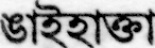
ঙাইহক্তা
